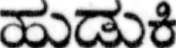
ಹುಡುಕಿ
